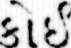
કોઈ
